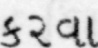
કરવા
